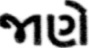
જાણે
